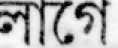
লাগে
